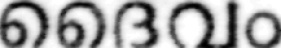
ദൈവം
